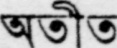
অতীত
